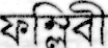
ফম্লিবী
